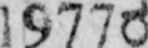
1977ರ
